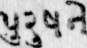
પુરુષને
